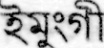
ইমুংগী
